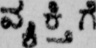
ವ್ಯಕ್ತಿಗೆ
